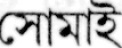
সোমাই
